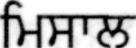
ਮਿਸਾਲ
